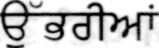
ਉੱਭਰੀਆਂ
